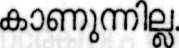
കാണുന്നില്ല.
